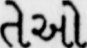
તેઓ
